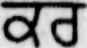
ਕਰ
